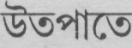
উতপাতে
